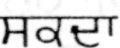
ਸਕਦਾ
